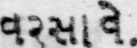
વરસાવે.
